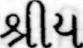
શ્રીય
